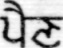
ਪੈਣ
